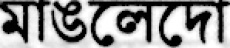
মাঙলেদো
